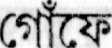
গোঁফে
